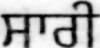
ਸਾਰੀ
